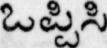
ಒಪ್ಪಿಸಿ
